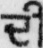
ਦੀ
